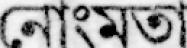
নোংমতা
